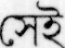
সেই
